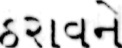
ઠરાવને
